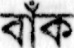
বাঁক
